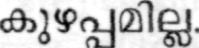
കുഴപ്പമില്ല.
